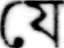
যে
